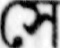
সে
